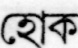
হোক
